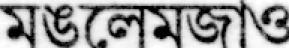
মঙলেমজাও
